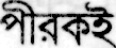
পীরকই
